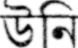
উনি
